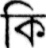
কি
